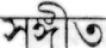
সঙ্গীত
